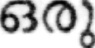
ഒരു
